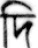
দি
